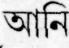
আনি
